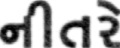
નીતરે
